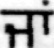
ਜਾਂ
